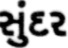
સુંદર
